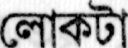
লোকটা
